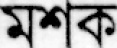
মশক
